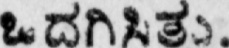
ಒದಗಿಸಿತು.
